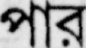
পার
